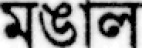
মঙাল
